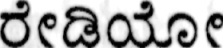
ರೇಡಿಯೋ
